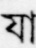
যা
